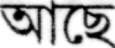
আছে
